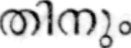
തിനും
